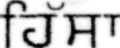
ਹਿੱਸਾ
